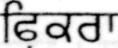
ਫ਼ਿਕਰਾ
